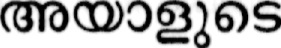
അയാളുടെ
